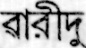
ৱারীদু
